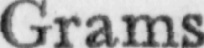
Grams
